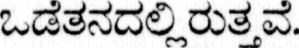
ಒಡೆತನದಲ್ಲಿರುತ್ತವೆ.
